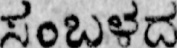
ಸಂಬಳದ
